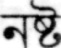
নষ্ট
